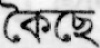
কৈছে
